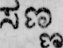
ಸಣ್ಣ
